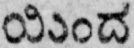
ಯಿಂದ
